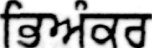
ਭਿਅੰਕਰ
